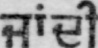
ਜਾਂਦੀ
